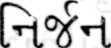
નિર્જન
